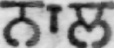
ਨਾਲ
